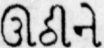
ઊઠીને
